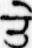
ਤੇ
